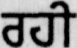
ਰਹੀ
